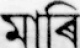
মাৰি
